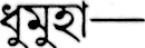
ধুমুহা-
